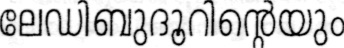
ലേഡിബുദൂറിൻ്റെയും
